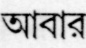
আবার
